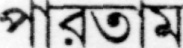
পারতাম
